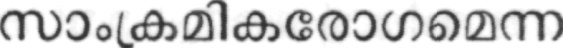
സാംക്രമികരോഗമെന്ന
